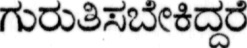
ಗುರುತಿಸಬೇಕಿದ್ದರೆ
